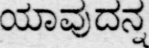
ಯಾವುದನ್ನ
